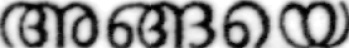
അങ്ങയെ
